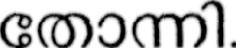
തോന്നി.
